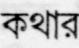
কথার
